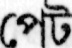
পেট
